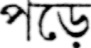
পড়ে
